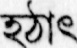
হঠাত্
